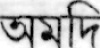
অমদি
